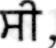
ਸੀ,
